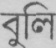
বুলি
